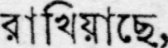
রাখিয়াছে,
